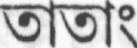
তাতাং
